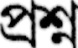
প্রশ্ন
